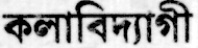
কলাবিদ্যাগী
